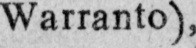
Warranto),
